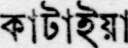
কাটাইয়া
